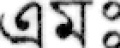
এমঃ
